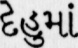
દેહુમાં
